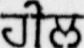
ਹੀਲ
